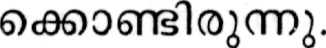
ക്കൊണ്ടിരുന്നു.
